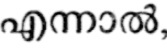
എന്നാല്‍,
